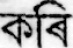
কৰি
